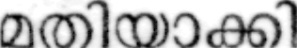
മതിയാക്കി
